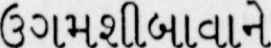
ઉગમશીબાવાને
